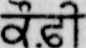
ਕੌਫ਼ੀ
